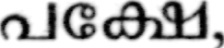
പക്ഷേ,
